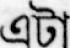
এটা
